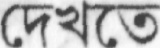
দেখতে
